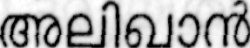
അലിഖാന്‍
